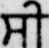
ਸੀ
